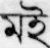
মই
